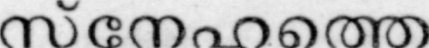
സ്നേഹത്തെ
